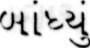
બાંધ્યું
